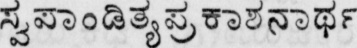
ಸ್ವಪಾಂಡಿತ್ಯಪ್ರಕಾಶನಾರ್ಥ
